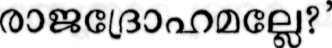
രാജദ്രോഹമല്ലേ?’
